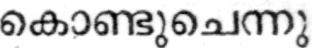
കൊണ്ടുചെന്നു
